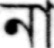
না
